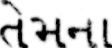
તેમના
